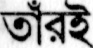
তাঁরই
